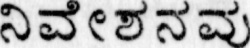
ನಿವೇಶನವು
